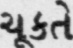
ચૂકતે
